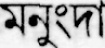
মনুংদা
